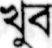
খুব
